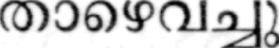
താഴെവച്ചു
